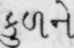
કુળને
